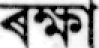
ৰক্ষা
